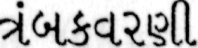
ત્રંબકવરણી
